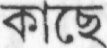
কাছে
